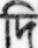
দি
